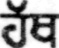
ਹੱਥ
